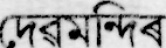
দেৱমন্দিৰ
